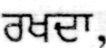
ਰਖਦਾ,
